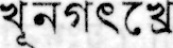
খূনগৎখ্রে
